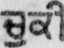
ਚੁਕੀ
